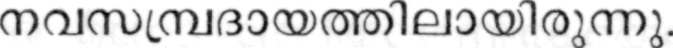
നവസമ്പ്രദായത്തിലായിരുന്നു.
